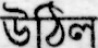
উঠিল
